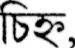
চিহ্ন,
